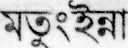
মতুংইন্না
